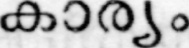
കാര്യം
